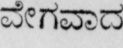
ವೇಗವಾದ
